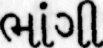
ભાંગી
